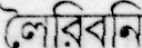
লৈরিবনি
